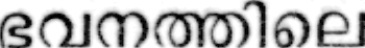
ഭവനത്തിലെ
